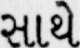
સાથે
